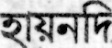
হায়নদি
